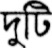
দুটি
